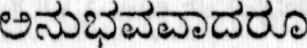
ಅನುಭವವಾದರೂ
